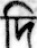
দি
